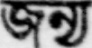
জন্য
